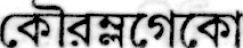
কৌরম্লগেকো
